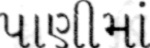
પાણીમાં
